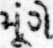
મૂંગે
